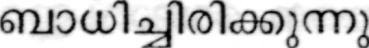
ബാധിച്ചിരിക്കുന്നു
